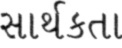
સાર્થક્તા
